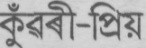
কুঁৱৰী-প্ৰিয়
